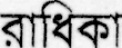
রাধিকা
